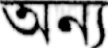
অন্য
